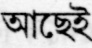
আছেই
